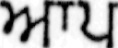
ਆਪ
